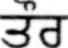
ਤੌਰ
